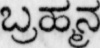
ಬ್ರಹ್ಮನ
